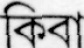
কিবা
